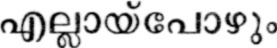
എല്ലായ്പോഴും
